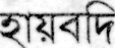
হায়বদি
